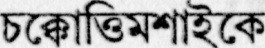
চক্কোত্তিমশাইকে
